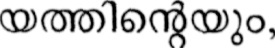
യത്തിന്റെയും,
